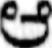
ಆ
